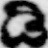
ಡಿ
